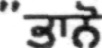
''ਭਾਨੋ
